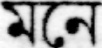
মনে
